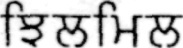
ਝਿਲਮਿਲ
